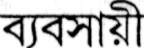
ব্যবসায়ী
